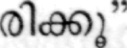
രിക്കൂ”
